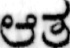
ಆತ
